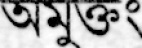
অমুক্তং
